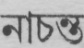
নাচন্ত
